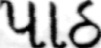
પાઠ
